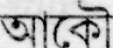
আকৌ
